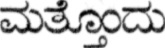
ಮತ್ತೊಂದು
